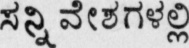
ಸನ್ನಿವೇಶಗಳಲ್ಲಿ
